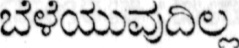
ಬೆಳೆಯುವುದಿಲ್ಲ
